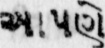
આપણે
